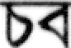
চব
